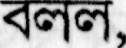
বলল,
